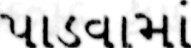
પાડવામાં
